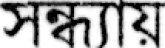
সন্ধ্যায়
